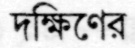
দক্ষিণের
